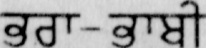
ਭਰਾ-ਭਾਬੀ
